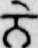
ਨੇ
